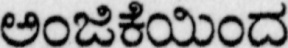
ಅಂಜಿಕೆಯಿಂದ
